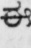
ಈ
